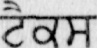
ਟੈਕਸ
